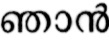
ഞാന്‍
